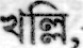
খল্লি,
